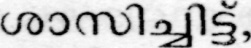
ശാസിച്ചിട്ട്,
